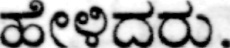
ಹೇಳಿದರು.
